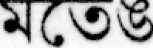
মতেঙ
